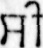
ਸੀ
